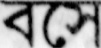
বসে
